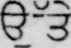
ਉੱਤੇ
